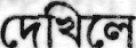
দেখিলে
